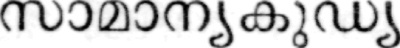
സാമാന്യകുഡ്യ
